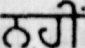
ਨਹੀਂ
